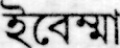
ইবেম্মা
